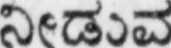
ನೀಡುವ
